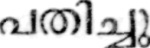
പതിച്ചു
